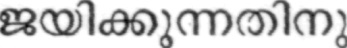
ജയിക്കുന്നതിനു
